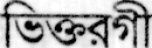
ভিক্তরগী
